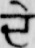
ਦੇ
